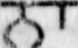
ਨਾ
